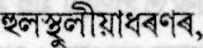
হুলস্হুলীয়াধৰণৰ,
